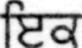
ਇਕ
